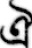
ঐ
